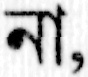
না,
